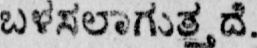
ಬಳಸಲಾಗುತ್ತದೆ.
